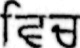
ਵਿਚ
